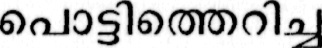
പൊട്ടിത്തെറിച്ച
